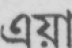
এয়া
